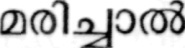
മരിച്ചാല്‍
